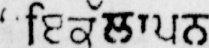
''ਇਕੱਲਾਪਨ
